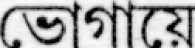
ভোগায়ে
